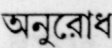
অনুরোধ
